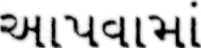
આપવામાં
